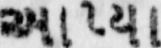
આપ્યા
